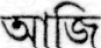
আজি
